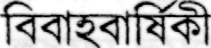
বিবাহবার্ষিকী
